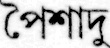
পৈশাদু
